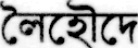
লৈহৌদে
